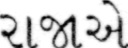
રાજાએ
